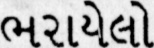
ભરાયેલો
